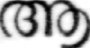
ആ
